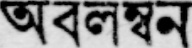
অবলম্বন
